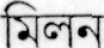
মিলন
